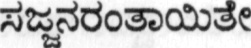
ಸಜ್ಜನರಂತಾಯಿತೇ
